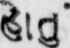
હોતું
